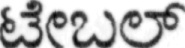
ಟೇಬಲ್
